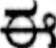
ಈ
